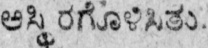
ಅಸ್ಥಿರಗೊಳಿಸಿತು.
